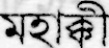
মহাক্কী
